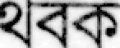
থবক
